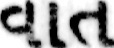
વાત
